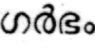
ഗര്‍ഭം
